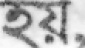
হয়,
